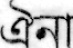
ঐনা
